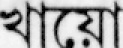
খায়ো
